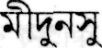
মীদুনসু
